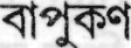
বাপুকণ
